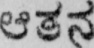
ಆತನ
